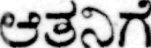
ಆತನಿಗೆ
